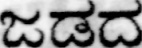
ಜಡದ
